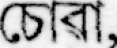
চোৱা,
